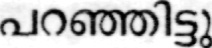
പറഞ്ഞിട്ടു
